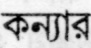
কন্যার
